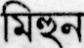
মিহুন
